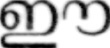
ഈ
